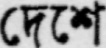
দেশে
